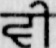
ਵੀ
